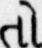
તો
